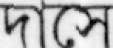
দাসে
